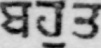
ਬਹੁਤ
